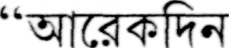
“আরেকদিন
